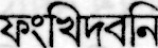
ফংখিদবনি
